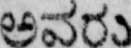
ಅವರು
